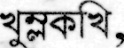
খুম্লকখি,
